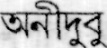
অনীদুবু
